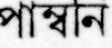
পাম্বনি
